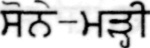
ਸੋਨੇ-ਮੜ੍ਹੀ
